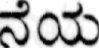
ನೆಯ
